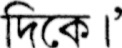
দিকে।'
